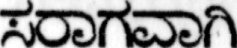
ಸರಾಗವಾಗಿ
